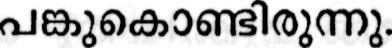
പങ്കുകൊണ്ടിരുന്നു.
